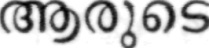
ആരുടെ
